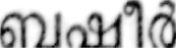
ബഷീര്‍
